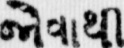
જોવાથી
